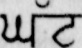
ਘੱਟ
